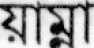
য়াম্না
